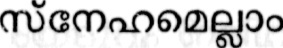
സ്നേഹമെല്ലാം
